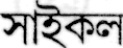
সাইকল
